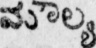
ಮೌಲ್ಯ
